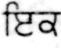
ਇਕ
